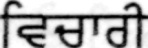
ਵਿਚਾਰੀ
